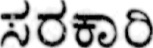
ಸರಕಾರಿ
